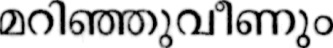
മറിഞ്ഞുവീണും
